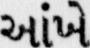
આંખે
